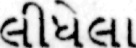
લીધેલા
